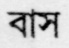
বাস
